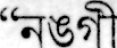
“নঙগী
